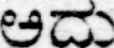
ಅದು
